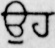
ਉਹ
